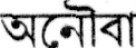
অনৌবা
